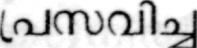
പ്രസവിച്ച
